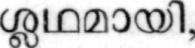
ശ്ലഥമായി,
